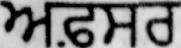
ਅਫ਼ਸਰ
